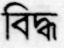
বিদ্ধ
